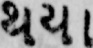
થયા
